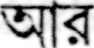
আর
